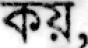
কয়,
